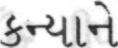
કન્યાને
